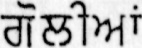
ਗੋਲੀਆਂ
